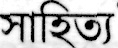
সাহিত্য
